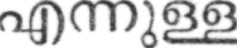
എന്നുള്ള
